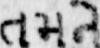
તમને
